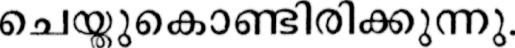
ചെയ്തുകൊണ്ടിരിക്കുന്നു.
